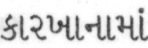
કારખાનામાં
